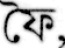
ফৈ,
